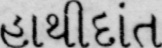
હાથીદાંત
